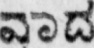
ವಾದ
